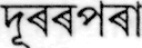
দূৰৰপৰা
